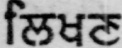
ਲਿਖਣ
